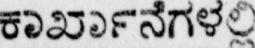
ಕಾರ್ಖಾನೆಗಳಲ್ಲಿ
